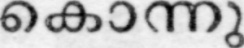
കൊന്നു
